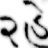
રહે
